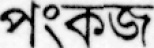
পংকজ
